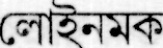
লোইনমক
